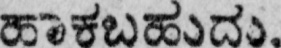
ಹಾಕಬಹುದು.
